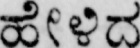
ಹೇಳಿದ
